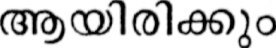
ആയിരിക്കും
